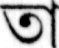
তা
